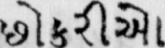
છોકરીઓ
